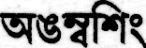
অঙম্বশিং
